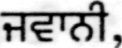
ਜਵਾਨੀ,
